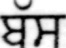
ਬੱਸ
